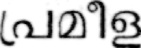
പ്രമീള
